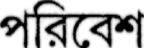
পরিবেশ
